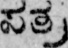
ಪತ್ರ
